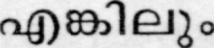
എങ്കിലും
